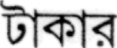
টাকার
